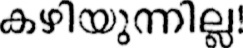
കഴിയുന്നില്ല!
